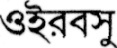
ওইরবসু
